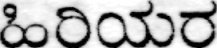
ಹಿರಿಯರ
